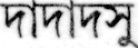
দাদাদসু
